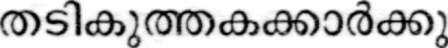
തടികുത്തകക്കാര്‍ക്കു
